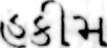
હકીમ
